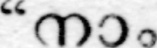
"നാം
